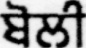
ਬੋਲੀ
